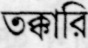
তক্কারি
